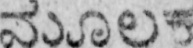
ಮೂಲಕ
